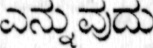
ಎನ್ನುವುದು
